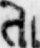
તો
